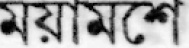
ময়ামশে
